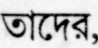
তাদের,
